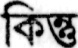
কিন্তু
